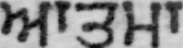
ਆਤਮਾ
